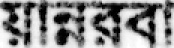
য়ান্নরবা
